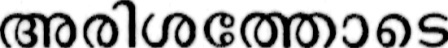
അരിശത്തോടെ
